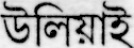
উলিয়াই
